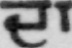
ਦਾ
